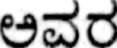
ಅವರ
